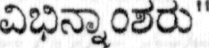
ವಿಭಿನ್ನಾಂಶರು”
